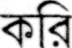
করি
